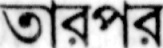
তারপর
